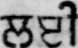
ਲਈ
